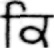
ਕਿ
